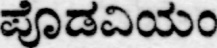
ಪೊಡವಿಯಂ
